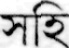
সহি
